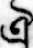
ঐ
